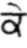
ਕੇ
